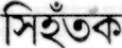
সিহঁতক
